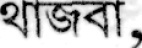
থাজবা,
